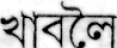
খাবলৈ
